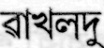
ৱাখলদু
